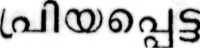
പ്രിയപ്പെട്ട
